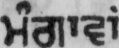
ਮੰਗਾਵਾਂ
